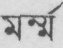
মৰ্ম্ম
